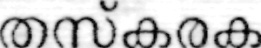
തസ്കരക
